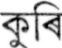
কুৰি
